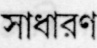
সাধারণ
